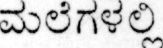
ಮಲೆಗಳಲ್ಲಿ
